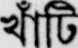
খাঁটি
